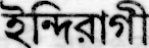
ইন্দিরাগী
